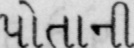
પોતાની
